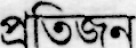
প্রতিজন
